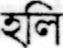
হলি
